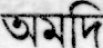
অমদি
